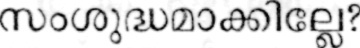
സംശുദ്ധമാക്കില്ലേ?
